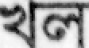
খল
